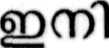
ഇനി
